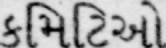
કમિટિઓ
